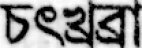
চৎখ্রব্রা
